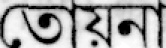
তোয়না
